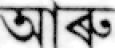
আৰু
